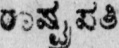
ರಾಷ್ಟ್ರಪತಿ
